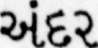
અંદર
